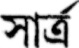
সার্ত্র
